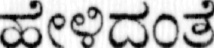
ಹೇಳಿದಂತೆ
